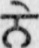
ਨੇ
